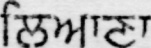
ਲਿਆਣਾ
